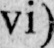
vi)
